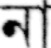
না
